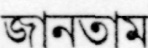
জানতাম
